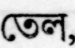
তেল,
